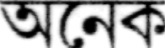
অনেক
